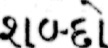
શબ્દો
